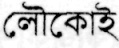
লৌকোই
